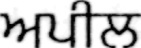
ਅਪੀਲ
